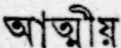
আত্মীয়
